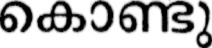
കൊണ്ടു
